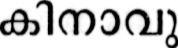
കിനാവു
